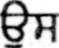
ਉਸ
